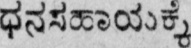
ಧನಸಹಾಯಕ್ಕೆ
